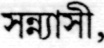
সন্ন্যাসী,
